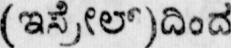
(ಇಸ್ರೇಲ್)ದಿಂದ
